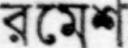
রমেশ
